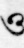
ও
